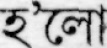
হ'লো
